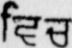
ਵਿਚ
